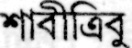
শাবীত্রিবু
